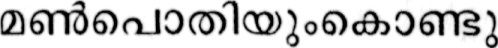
മണ്‍പൊതിയുംകൊണ്ടു
